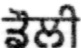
ਡੌਲੀ
